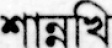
শান্নখি
